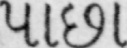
પાછા
